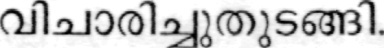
വിചാരിച്ചുതുടങ്ങി.
